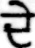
ਦੇ
